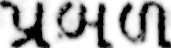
પ્રબળ
